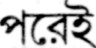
পরেই
